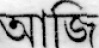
আজি
